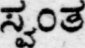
ಸ್ವಂತ
